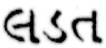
લડત
